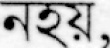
নহয়,
